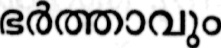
ഭര്‍ത്താവും
